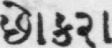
છોકરા
